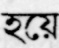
হয়ে
